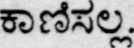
ಕಾಣಿಸಲ್ಲ.
